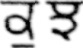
ਕੁਝ
